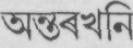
অন্তৰখনি
